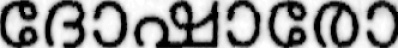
ദോഷാരോ
